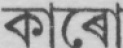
কাৰো
